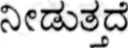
ನೀಡುತ್ತದೆ
